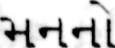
મનનો
